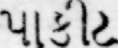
પાકીટ
